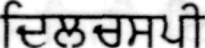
ਦਿਲਚਸਪੀ
